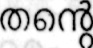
തന്റെ
